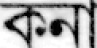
কনা
